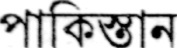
পাকিস্তান
